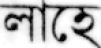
লাহে
